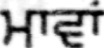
ਮਾਵਾਂ
